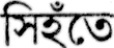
সিহঁতে
